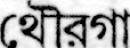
থৌরগা
